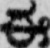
ಈ
